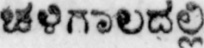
ಚಳಿಗಾಲದಲ್ಲಿ
